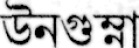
উনগুম্না
